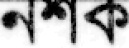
নশক
